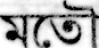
মতৌ
